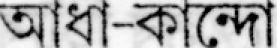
আধা-কান্দো
